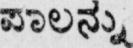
ಪಾಲನ್ನು
